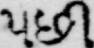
પછી
